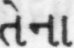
તેના
